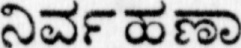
ನಿರ್ವಹಣಾ
